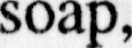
Soap,
